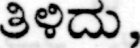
ತಿಳಿದು,
